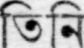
তিনি
